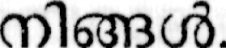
നിങ്ങള്‍.
